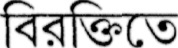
বিরক্তিতে
